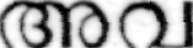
അവ
